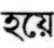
হয়ে
